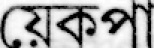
য়েকপা
